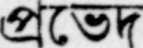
প্রভেদ
